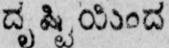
ದೃಷ್ಟಿಯಿಂದ
